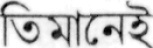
তিমানেই
